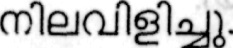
നിലവിളിച്ചു.
